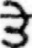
ਤੇ
